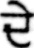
ਦੇ
